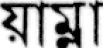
য়াম্না
